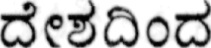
ದೇಶದಿಂದ
